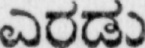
ಎರಡು
